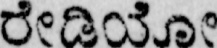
ರೇಡಿಯೋ
